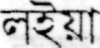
লইয়া
